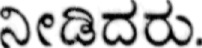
ನೀಡಿದರು.
